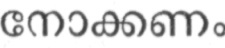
നോക്കണം
